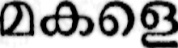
മകളെ
